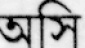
অসি
